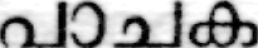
പാചക
